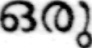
ഒരു
